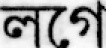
লগে
